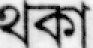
থকা
